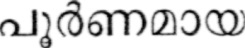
പൂര്‍ണമായ
